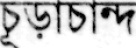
চূড়াচান্দ
